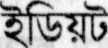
ইডিয়ট
